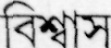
বিশ্বাস
